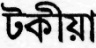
টকীয়া
